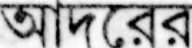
আদরের
